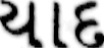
યાદ
